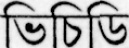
ভিচিডি
